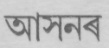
আসনৰ
